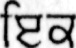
ਇਕ
